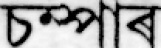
চম্পাৰ
